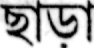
ছাড়া
